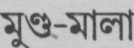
মুণ্ড-মালা
